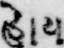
હોય
